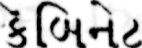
કૅબિનેટ
